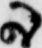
જે
